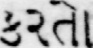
કરતો
